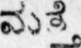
ಮತ್ತೆ
